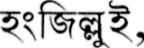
হংজিল্লুই,
